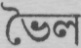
ভৈল
